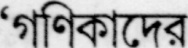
‘গণিকাদের
